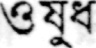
ওষুধ
